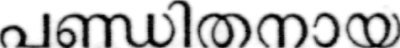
പണ്ഡിതനായ
